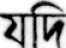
যদি
